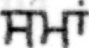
ਸਮਾਂ
